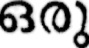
ഒരു
